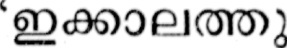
‘ഇക്കാലത്തു
